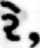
રે,
